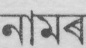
নামৰ
